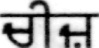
ਚੀਜ਼
